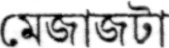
মেজাজটা
